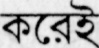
করেই
